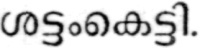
ശട്ടംകെട്ടി.
